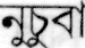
নুচুবা
